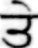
ਤੇ
